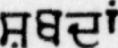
ਸ਼ਬਦਾਂ
